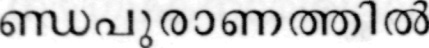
ണ്ഡപുരാണത്തില്‍
